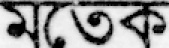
মতেক
